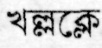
খল্লক্লে
